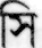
সি
